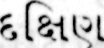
દક્ષિણ
